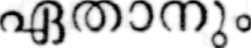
ഏതാനും
